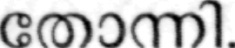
തോന്നി.
